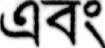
এবং
